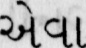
એવા
